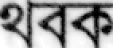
থবক
